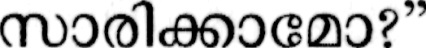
സാരിക്കാമോ?”
